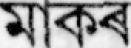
মাকৰ
